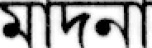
মাদনা
